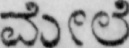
ಮೇಲೆ
